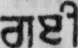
ਗਈ
